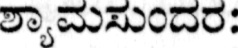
ಶ್ಯಾಮಸುಂದರ:
